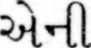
એની
